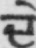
ਦੇ
